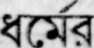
ধর্মের
